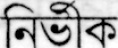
নিৰ্ভীক
